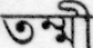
তম্মী
